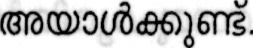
അയാള്‍ക്കുണ്ട്.
